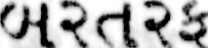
બરતરફ
